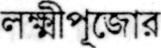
লক্ষ্মীপূজোর
